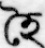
হৈ
